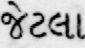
જેટલા
